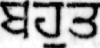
ਬਹੁਤ
